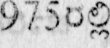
975ರಲ್ಲಿ
